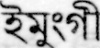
ইমুংগী
